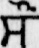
ਸੌਂ
